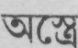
অস্ত্ৰে
